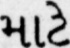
માટે
